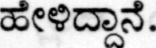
ಹೇಳಿದ್ದಾನೆ.
